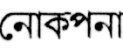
নোকপনা
